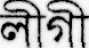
লীগী
